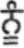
ਨੂੰ
